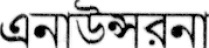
এনাউন্সরনা
